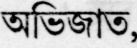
অভিজাত,
